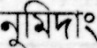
নুমিদাং
